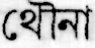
থৌনা
